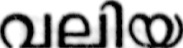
വലിയ
